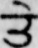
ਤੇ
